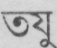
তযু
